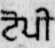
ਟੋਪੀ
